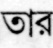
তার
